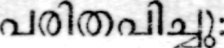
പരിതപിച്ചു:
